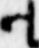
ન
